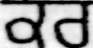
ਕਰ
